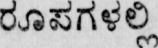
ರೂಪಗಳಲ್ಲಿ
